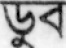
ডুব
